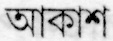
আকাশ
